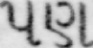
પણ
